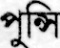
পুন্সি
